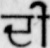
ਦੀ
